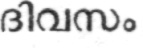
ദിവസം
